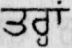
ਤਰ੍ਹਾਂ
